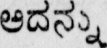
ಅದನ್ನು
